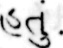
હતું.
